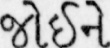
જોઈને
